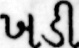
ખડી
